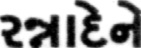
રન્નાદેને
